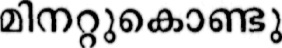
മിനറ്റുകൊണ്ടു
